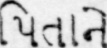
પિતાને
